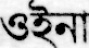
ওইনা
